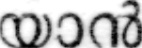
യാന്‍
